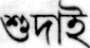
শুদাই
